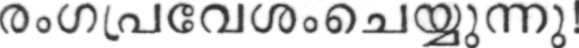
രംഗപ്രവേശംചെയ്യുന്നു!
